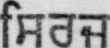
ਸਿਰਜ
